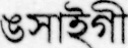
ঙসাইগী
